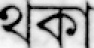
থকা
